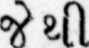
જેથી
